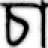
চা
